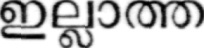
ഇല്ലാത്ത
